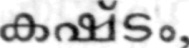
കഷ്ടം,
